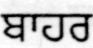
ਬਾਹਰ
